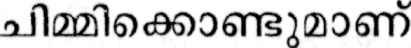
ചിമ്മിക്കൊണ്ടുമാണ്
